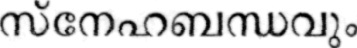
സ്നേഹബന്ധവും
